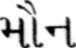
મૌન
